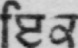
ਇਕ
